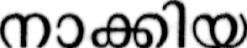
നാക്കിയ
